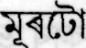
মূৰটো
